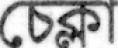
চেক্লা
